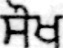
ਸੌਖ
